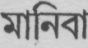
মানিবা
